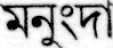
মনুংদা
